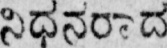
ನಿಧನರಾದ
